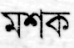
মশক
